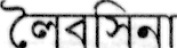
লৈবসিনা
